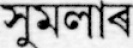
সুমলাৰ
